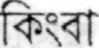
কিংবা
